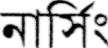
নার্সিং
